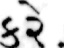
કરે.
